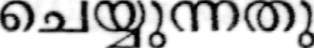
ചെയ്യുന്നതു
